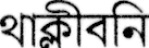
থাক্লীবনি
